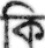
কি
